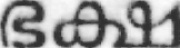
ഭക്ഷ
